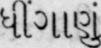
ધીંગાણું
